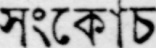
সংকোচ
